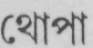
থোপা
